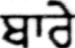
ਬਾਰੇ
